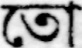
তো
